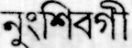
নুংশিবগী
